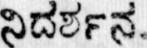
ನಿದರ್ಶನ.
